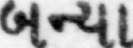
બન્યા
